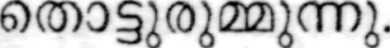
തൊട്ടുരുമ്മുന്നു.
